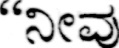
"ನೀವು
